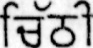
ਚਿੱਠੀ
